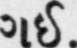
ગઈ.
